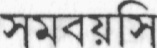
সমবয়সি
